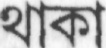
থাকা
